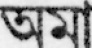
অমা
